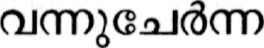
വന്നുചേര്‍ന്ന
